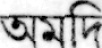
অমদি
